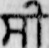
ਸੀ
